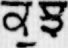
ਕੁਝ
